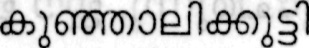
കുഞ്ഞാലിക്കുട്ടി
